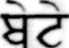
ਬੇਟੇ
